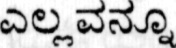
ಎಲ್ಲವನ್ನೂ
